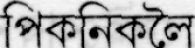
পিকনিকলৈ
